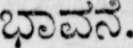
ಭಾವನೆ.
